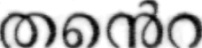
തന്റെ
